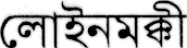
লোইনমক্কী
